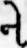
ને
